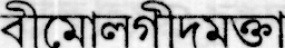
বীমোলগীদমক্তা
